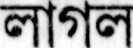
লাগল
